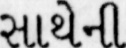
સાથેની
